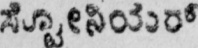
ಸ್ಟೋನಿಯರ್
